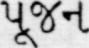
પૂજન
